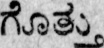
ಗೊತ್ತು
